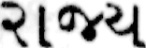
રાજ્ય
